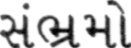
સંભ્રમો
